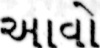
આવો
